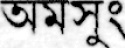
অমসুং
